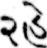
રહે
